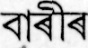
বাৰীৰ
